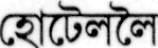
হোটেললৈ
